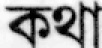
কথা
